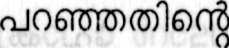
പറഞ്ഞതിന്റെ
